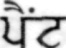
ਪੈਂਟ
